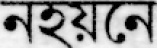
নহয়নে
